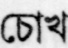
চোখ
